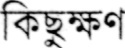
কিছুক্ষণ
